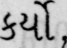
કર્યો,
